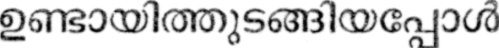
ഉണ്ടായിത്തുടങ്ങിയപ്പോള്‍
